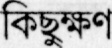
কিছুক্ষণ
